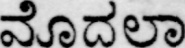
ಮೊದಲಾ
